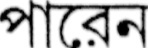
পারেন
